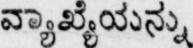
ವ್ಯಾಖ್ಯೆಯನ್ನು
